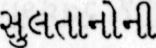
સુલતાનોની
